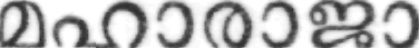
മഹാരാജാ
